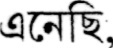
এনেছি,
